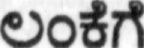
ಲಂಕೆಗೆ
